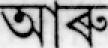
আৰু
